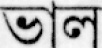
ভাল
